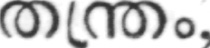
തന്ത്രം,
